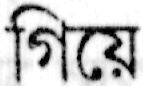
গিয়ে
